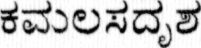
ಕಮಲಸದೃಶ
